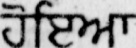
ਹੋਇਆ
